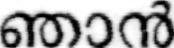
ഞാന്‍
